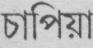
চাপিয়া
